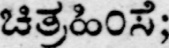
ಚಿತ್ರಹಿಂಸೆ;
